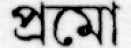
প্রমো
